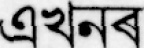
এখনৰ
